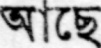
আছে
